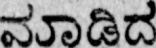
ಮಾಡಿದ
